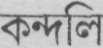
কন্দলি
